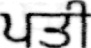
ਪਤੀ
